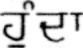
ਹੁੰਦਾ
